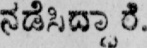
ನಡೆಸಿದ್ದಾರೆ.
